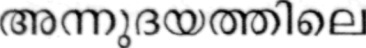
അന്നുദയത്തിലെ
